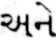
અને
